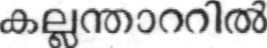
കല്ലന്താററില്‍
